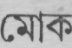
মোক
